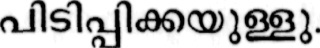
പിടിപ്പിക്കയുള്ളു.
